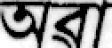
অৱা
